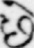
છે
